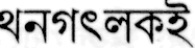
থনগৎলকই
